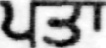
ਪਤਾ
